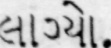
લાગ્યો.
